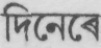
দিনেৰে
